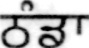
ਠੰਡਾ
